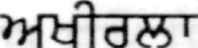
ਅਖੀਰਲਾ
